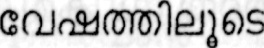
വേഷത്തിലൂടെ
